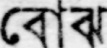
বোঝ
